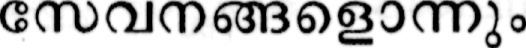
സേവനങ്ങളൊന്നും
